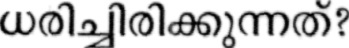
ധരിച്ചിരിക്കുന്നത്?
